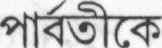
পার্বতীকে
